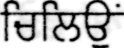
ਚਿਲਿਉਂ
